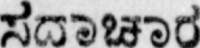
ಸದಾಚಾರ
